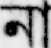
না
